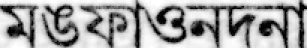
মঙফাওনদনা
